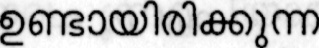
ഉണ്ടായിരിക്കുന്ന
